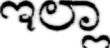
ಇಲ್ಲಾ
